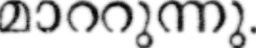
മാററുന്നു.
